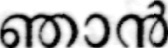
ഞാന്‍
